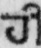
ਹੀ
